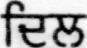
ਦਿਲ
